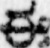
ಈ
